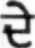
ਦੇ
